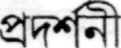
প্রদর্শনী
